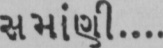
સમાંણી....
